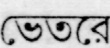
ভেতরে
